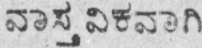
ವಾಸ್ತವಿಕವಾಗಿ
